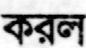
করল
